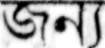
জন্য
